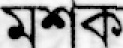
মশক
